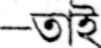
-তাই
